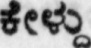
ಕೇಳ್ದು
